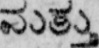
ಮತ್ತು
